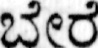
ಬೇರೆ
